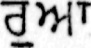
ਰੁਆ
